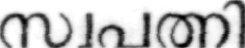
സ്വപത്നി
